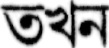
তখন
